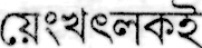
য়েংখৎলকই
